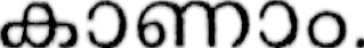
കാണാം.
